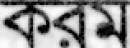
করম
